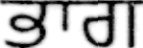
ਭਾਗ
